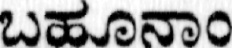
ಬಹೂನಾಂ
